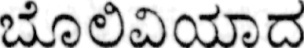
ಬೊಲಿವಿಯಾದ
